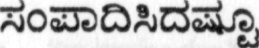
ಸಂಪಾದಿಸಿದಷ್ಟೂ
